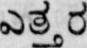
ಎತ್ತರ
